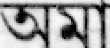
অমা
